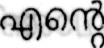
എന്റെ
